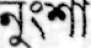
নুংশা
